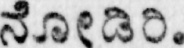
ನೋಡಿರಿ.
